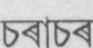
চৰাচৰ
